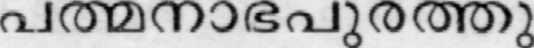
പത്മനാഭപുരത്തു
